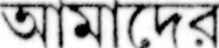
আমাদের
